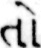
તો
